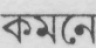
কমনে
